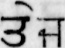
ਤੇਜ
